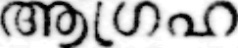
ആഗ്രഹ
